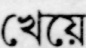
খেয়ে
